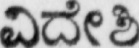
ವಿದೇಶಿ
